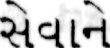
સેવાને
